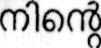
നിന്റെ
